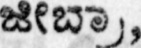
ಜೀಬ್ರಾ,
